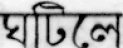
ঘটিলে
